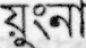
য়ুংনা
